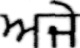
ਅਜੇ
